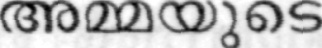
അമ്മയുടെ
